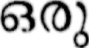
ഒരു
